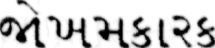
જોખમકારક
